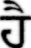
ਹੈ
